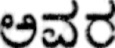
ಅವರ
